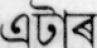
এটাৰ
